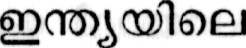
ഇന്ത്യയിലെ
